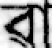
ৱা
